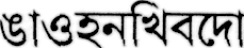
ঙাওহনখিবদো
